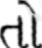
તો
